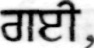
ਗਈ,
